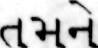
તમને
